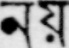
নয়
